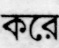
করে
